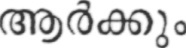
ആര്‍ക്കും
